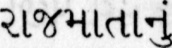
રાજમાતાનું
